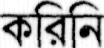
করিনি
